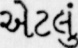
એટલું
